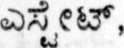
ಎಸ್ಟೇಟ್,
